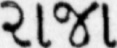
રાજા
